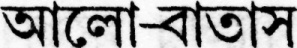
আলো-বাতাস
